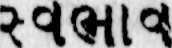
સ્વભાવ
